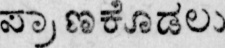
ಪ್ರಾಣಕೊಡಲು
